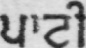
ਪਾਟੀ
